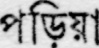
পড়িয়া
